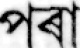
পৰা
